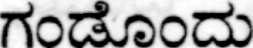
ಗಂಡೊಂದು
